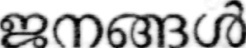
ജനങ്ങള്‍
